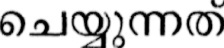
ചെയ്യുന്നത്
